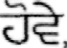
ਹੋਵੇ,
